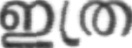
ഇത്ര
